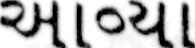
આવ્યા
